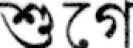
শুগে
